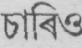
চাৰিও
